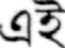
এই
